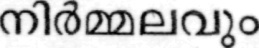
നിര്‍മ്മലവും
